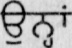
ਉਨ੍ਹਾਂ
